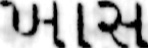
ખાસ
